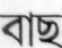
বাছ
